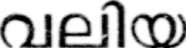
വലിയ
